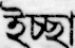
ইচ্ছা
